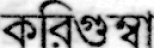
করিগুম্বা
